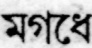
মগধে
